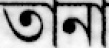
তানা
